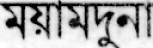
ময়ামদুনা
